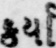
કર્યા
